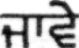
ਜਾਵੇ
